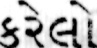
કરેલો
